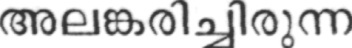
അലങ്കരിച്ചിരുന്ന
